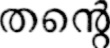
തന്റെ
